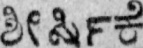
ಶೀರ್ಷಿಕೆ
